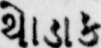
થોડાક
